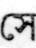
সে
